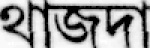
থাজদা
